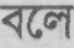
বলে
